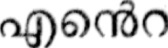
എന്റെ
